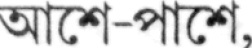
আশে-পাশে,
